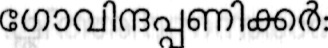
ഗോവിന്ദപ്പണിക്കര്‍:
